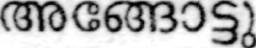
അങ്ങോട്ടു
